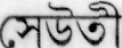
সেউতী
